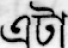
এটা
